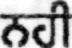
ਨਹੀ
